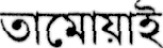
তামোয়াই
